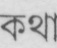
কথা
